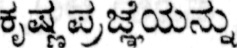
ಕೃಷ್ಣಪ್ರಜ್ಞೆಯನ್ನು
